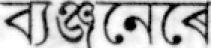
ব্যঞ্জনেৰে
